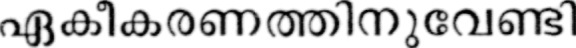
ഏകീകരണത്തിനുവേണ്ടി
